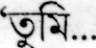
'তুমি...
